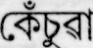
কেঁচুৱা
